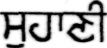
ਸੁਹਾਣੀ
